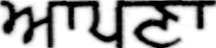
ਆਪਣਾ
